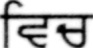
ਵਿਚ
